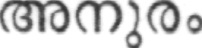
അനുരം
